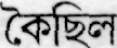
কৈছিল
